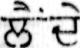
ਲੈਂਦੇ
